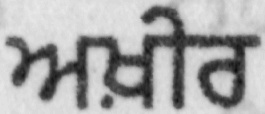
ਅਖ਼ੀਰ
